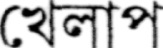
খেলাপ
